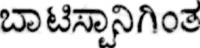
ಬಾಟಿಸ್ಟಾನಿಗಿಂತ
